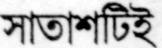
সাতাশটিই
